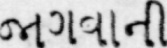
જાગવાની
